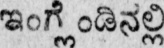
ಇಂಗ್ಲೆಂಡಿನಲ್ಲಿ
